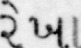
રેખા
